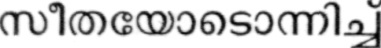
സീതയോടൊന്നിച്ച്
